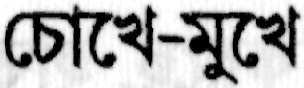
চোখে-মুখে
